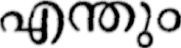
എന്തും
